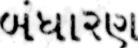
બંધારણ
